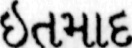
ઇતમાદ
